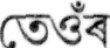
তেওঁৰ
